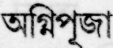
অগ্নিপূজা
